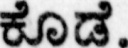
ಕೊಡೆ.
